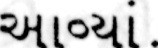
આવ્યાં.
